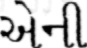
એની
